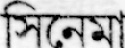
সিনেমা
